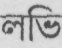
লভি
